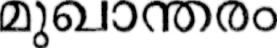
മുഖാന്തരം
